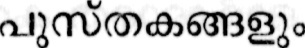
പുസ്തകങ്ങളും
